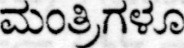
ಮಂತ್ರಿಗಳೂ
